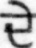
ਦੇ
